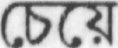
চেয়ে
